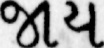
જાય
